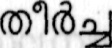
തീര്‍ച്ച
